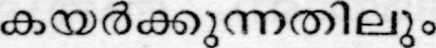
കയര്‍ക്കുന്നതിലും
